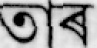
তাৰ
